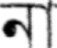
না
